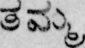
ತಮ್ಮ
